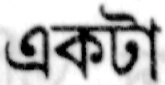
একটা
